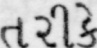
તરીકે
